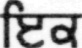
ਇਕ
